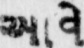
આવે
